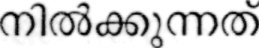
നില്‍ക്കുന്നത്
